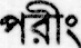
পরীং
